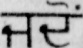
ਜਦੋਂ
